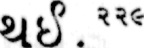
થઈ.૨૨૯
